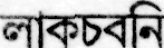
লাকচবনি
